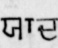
ਯਾਦ
